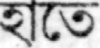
হাতে
